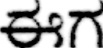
ಈಗ
